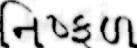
નિષ્ફળ
